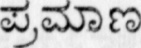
ಪ್ರಮಾಣ
